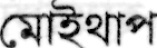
মোইথাপ
